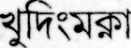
খুদিংমক্না
